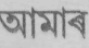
আমাৰ
